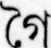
গৈ
